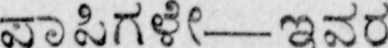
ಪಾಪಿಗಳೇ-ಇವರ
